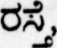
ರಸ್ತೆ,
